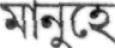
মানুহে
